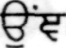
ਉਂਞ
